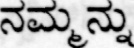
ನಮ್ಮನ್ನು
